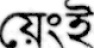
য়েংই
